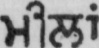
ਮੀਲਾਂ
